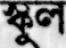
স্কুল
